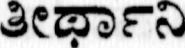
ತೀರ್ಥಾನಿ
